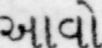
આવો
